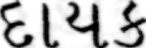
દાયક
